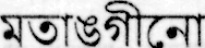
মতাঙগীনো
